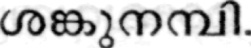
ശങ്കുനമ്പി.
